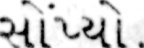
સોંપ્યો.
